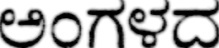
ಅಂಗಳದ
